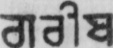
ਗਰੀਬ
